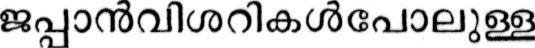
ജപ്പാന്‍വിശറികള്‍പോലുള്ള
